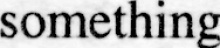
something
